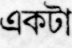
একটা
